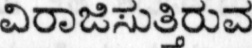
ವಿರಾಜಿಸುತ್ತಿರುವ
